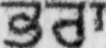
ਭਰਾ
